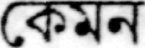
কেমন
